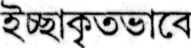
ইচ্ছাকৃতভাবে
